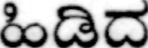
ಹಿಡಿದ
